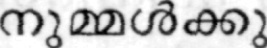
നുമ്മള്‍ക്കു
